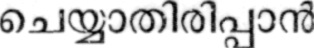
ചെയ്യാതിരിപ്പാന്‍
